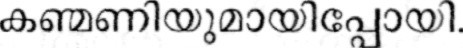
കണ്മണിയുമായിപ്പോയി.
